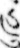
હું
